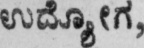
ಉದ್ಯೋಗ,
